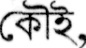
কৌই,
